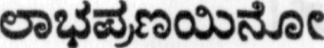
ಲಾಭಪ್ರಣಯಿನೋ
